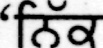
'ਨਿੱਕ
